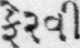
ફેરવી
